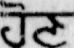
ਹੋਣ
